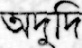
অদুদি
